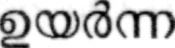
ഉയര്‍ന്ന
